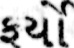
ફર્યો
